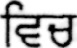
ਵਿਚ
